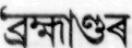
'ব্রহ্মাণ্ডৰ
